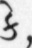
કે,
